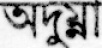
অদুম্না
